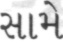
સામે
